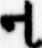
ન
